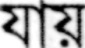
যায়
